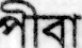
পীবা
